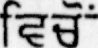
ਵਿਚੋਂ
